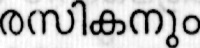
രസികനും
